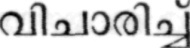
വിചാരിച്ച്
